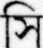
সি
